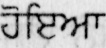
ਹੋਇਆ
